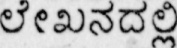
ಲೇಖನದಲ್ಲಿ
